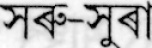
সৰু-সুৰা
